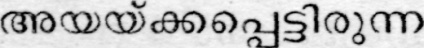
അയയ്ക്കപ്പെട്ടിരുന്ന
